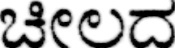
ಚೀಲದ
